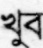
খুব
